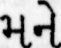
મને
